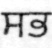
ਸਭ
